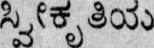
ಸ್ವೀಕೃತಿಯ
